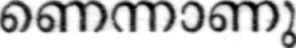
ണെന്നാണു
